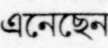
এনেছেন
